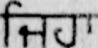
ਜਿਹਾ
